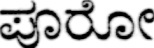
ಪೂರೋ
